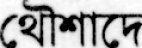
থৌশাদে
